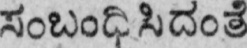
ಸಂಬಂಧಿಸಿದಂತೆ
